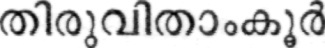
തിരുവിതാംകൂര്‍
